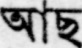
আছ
